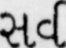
સર્વ
